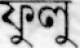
ফুলু
